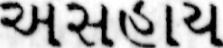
અસહાય
